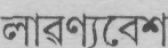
লাৱণ্যবেশ
